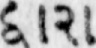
દ્વારા
